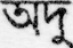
অদু
